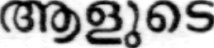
ആളുടെ
